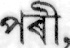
পৰী,
